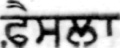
ਫ਼ੈਸਲਾ
